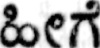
ಹೀಗೆ
